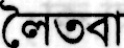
লৈতবা
